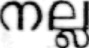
നല്ല
